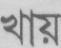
খায়
